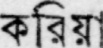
করিয়া
